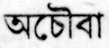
অচৌবা
